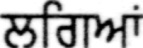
ਲਗਿਆਂ
